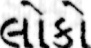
લોકો
